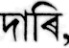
দাৰি,
